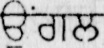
ਉਂਗਲ
